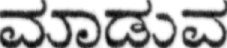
ಮಾಡುವ
